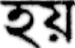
হয়
